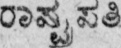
ರಾಷ್ಟ್ರಪತಿ
